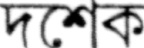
দশেক
